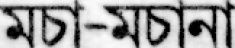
মচা-মচানা
